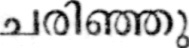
ചരിഞ്ഞു
